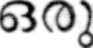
ഒരു
